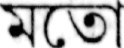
মতো
